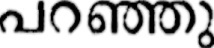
പറഞ്ഞു
